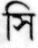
সি
